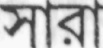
সারা
